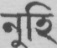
নুহি
